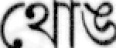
থোঙ
